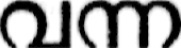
വന്ന
